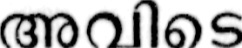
അവിടെ
